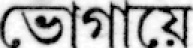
ভোগায়ে
